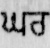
ਘਰ
